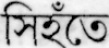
সিহঁতে
